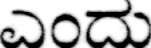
ಎಂದು
